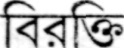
বিরক্তি
